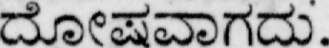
ದೋಷವಾಗದು.
